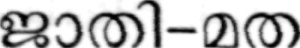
ജാതി-മത
